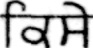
ਕਿਸੇ
